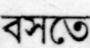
বসতে
